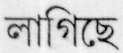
লাগিছে
